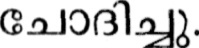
ചോദിച്ചു.
